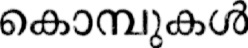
കൊമ്പുകള്‍
